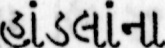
હાંડલાંના
